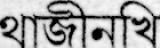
থাজীনখি
